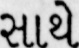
સાથે
